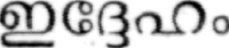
ഇദ്ദേഹം
